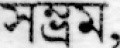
সম্ভ্রম,
